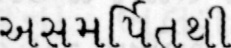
અસનર્પિતથી
